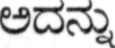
ಅದನ್ನು
